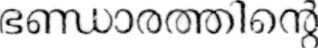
ഭണ്ഡാരത്തിന്റെ
